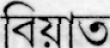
বিয়াত
